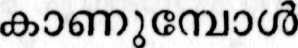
കാണുമ്പോള്‍
